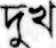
দুখ
